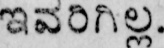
ಇವರಿಗಿಲ್ಲ.
